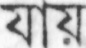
যায়
